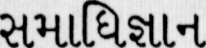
સમાધિજ્ઞાન
